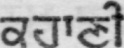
ਕਹਾਣੀ
